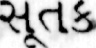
સૂતક
